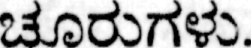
ಚೂರುಗಳು.
